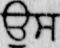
ਉਸ
